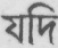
যদি
